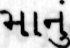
માનું
